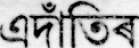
এদাঁতিৰ
